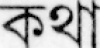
কথা
